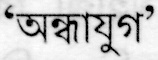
‘অন্ধাযুগ’
